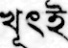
খূৎই
